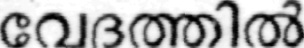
വേദത്തില്‍
